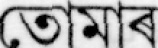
তোমাৰ
